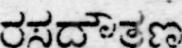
ರಸದೌತಣ
